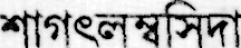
শাগৎলম্বসিদা
